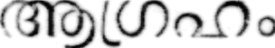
ആഗ്രഹം
